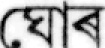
ঘোৰ
